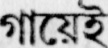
গায়েই
